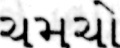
ચમચો
